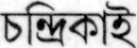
চন্দ্রিকাই
